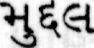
મુદ્દલ
